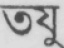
তযু
